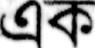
এক
